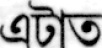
এটাত
